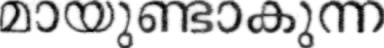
മായുണ്ടാകുന്ന
